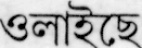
ওলাইছে
